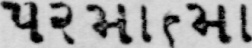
પરમાત્મા
